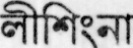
লীশিংনা
